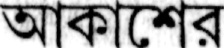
আকাশের
